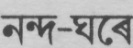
নন্দ-ঘৰে
